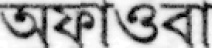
অফাওবা
